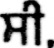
ਸੀ,
